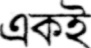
একই
